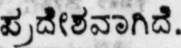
ಪ್ರದೇಶವಾಗಿದೆ.
